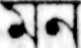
মন
